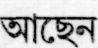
আছেন
